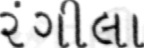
રંગીલા
